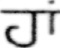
ਹਾਂ
